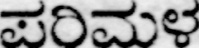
ಪರಿಮಳ
